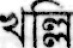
খল্লি
